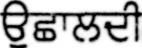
ਉਛਾਲਦੀ
